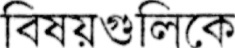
বিষয়গুলিকে
